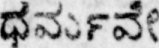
ಧರ್ಮವೇ
